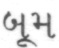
બૂમ
